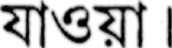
যাওয়া।
